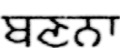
ਬਣਨਾ
